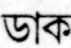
ডাক
